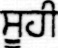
ਸੂਹੀ
